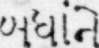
બધાંને
